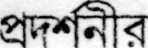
প্রদর্শনীর
